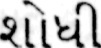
શોધી
